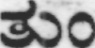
ತುಂ
